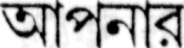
আপনার
